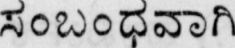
ಸಂಬಂಧವಾಗಿ
